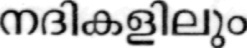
നദികളിലും
